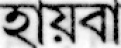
হায়বা
